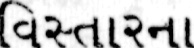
વિસ્તારના
